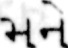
મને
